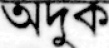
অদুক
